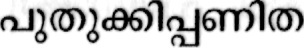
പുതുക്കിപ്പണിത
